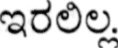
ಇರಲಿಲ್ಲ.
